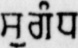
ਸੁੰਗਧ
